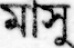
মাসু
